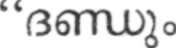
"ദണ്ഡും
